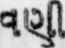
વણી
